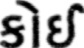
કોઈ
